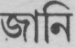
জানি
